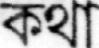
কথা
